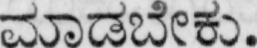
ಮಾಡಬೇಕು.
